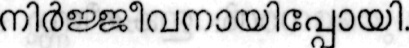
നിര്‍ജ്ജീവനായിപ്പോയി.
